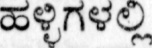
ಹಳ್ಳಿಗಳಲ್ಲಿ
